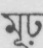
মূঢ়
